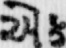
એક
